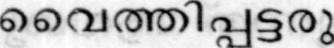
വൈത്തിപ്പട്ടരു
